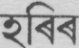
হৰিৰ
